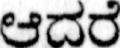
ಆದರೆ
